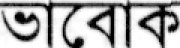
ভাবোক
